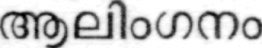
ആലിംഗനം
